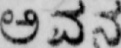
ಅವನ
